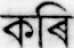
কৰি
